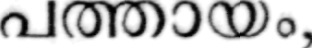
പത്തായം,
